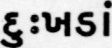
દુઃખડાં
